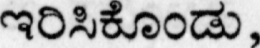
ಇರಿಸಿಕೊಂಡು,
